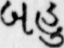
બહુ
